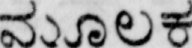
ಮೂಲಕ
